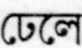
ঢেলে
